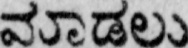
ಮಾಡಲು
